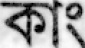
কাং
